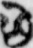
છે
